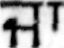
ਜਾ
